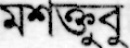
মশক্তুবু
